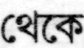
থেকে
